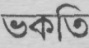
ভকতি
